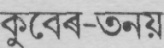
কুবেৰ-তনয়
